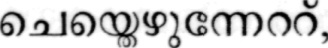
ചെയ്തെഴുന്നേററ്,
